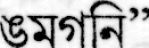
ঙমগনি”
